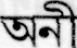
অনী
